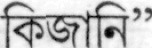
কিজানি"
